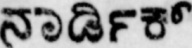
ನಾರ್ಡಿಕ್
